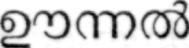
ഊന്നല്‍
